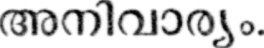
അനിവാര്യം.
